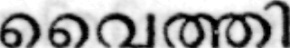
വൈത്തി
